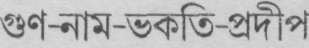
গুণ-নাম-ভকতি-প্ৰদীপ
